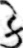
કે
